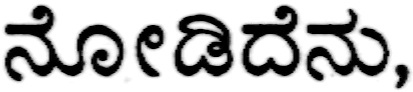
ನೋಡಿದೆನು,
